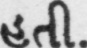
હતી.
